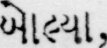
બોલ્યા,
